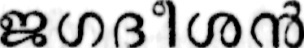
ജഗദീശന്‍
